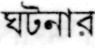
ঘটনার
